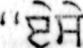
''ਏਸੇ
